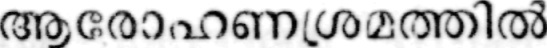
ആരോഹണശ്രമത്തില്‍
